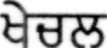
ਖੇਚਲ
